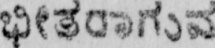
ಭೀತರಾಗುವ
